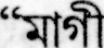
“মাগী
